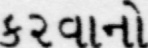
કરવાનો
